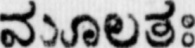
ಮೂಲತಃ
